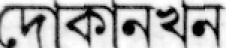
দোকানখন
